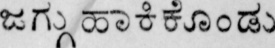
ಜಗ್ಗುಹಾಕಿಕೊಂಡು
